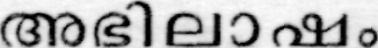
അഭിലാഷം
